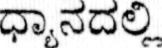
ಧ್ಯಾನದಲ್ಲಿ
